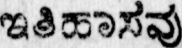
ಇತಿಹಾಸವು
